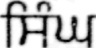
ਸਿੰਘ
